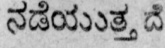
ನಡೆಯುತ್ತದೆ
